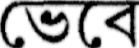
ভেবে
